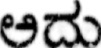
ಅದು
